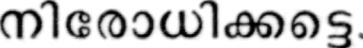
നിരോധിക്കട്ടെ.
